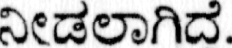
ನೀಡಲಾಗಿದೆ.
